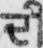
ਦੀ
